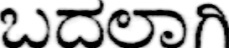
ಬದಲಾಗಿ
